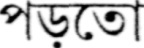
পড়তো
